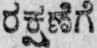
ರಕ್ಷಣೆಗೆ
